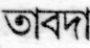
তাবদা
